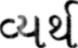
વ્યર્થ
